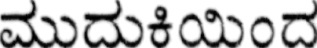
ಮುದುಕಿಯಿಂದ
